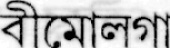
বীমোলগা
